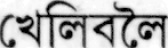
খেলিবলৈ
